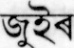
জুইৰ
